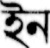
ইন
